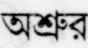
অশ্রুর
